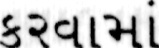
કરવામાં
